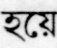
হয়ে
